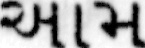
આમ
